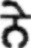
ਨੇ
